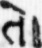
તો
